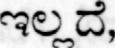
ಇಲ್ಲದೆ,
